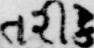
તરીકે
